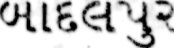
બાદલપુર
